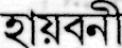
হায়বনী
